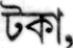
টকা,
